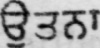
ਉਤਨਾ
